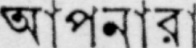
আপনারা
